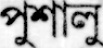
পুশালু
